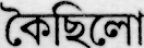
কৈছিলো
